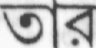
তার
